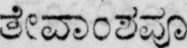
ತೇವಾಂಶವೂ
